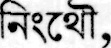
নিংথৌ,
